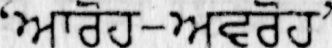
''ਆਰੋਹ-ਅਵਰੋਹ'
